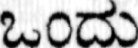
ಒಂದು
